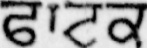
ਫਾਟਕ
